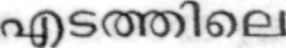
എടത്തിലെ
